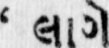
'લાગે
